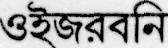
ওইজরবনি
